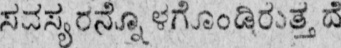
ಸದಸ್ಯರನ್ನೊಳಗೊಂಡಿರುತ್ತದೆ.
